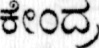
ಕೇಂದ್ರ
